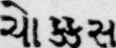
ચોક્કસ
